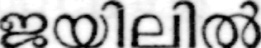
ജയിലില്‍
